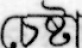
চেষ্টা
